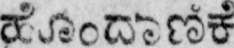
ಹೊಂದಾಣಿಕೆ
